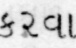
કરવા
